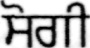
ਸੋਗੀ
